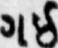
ગઈ
